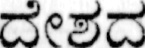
ದೇಶದ
